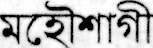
মহৌশাগী
